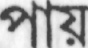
পায়
